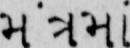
મંત્રમાં
